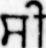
ਸੀ
